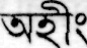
অহীং
